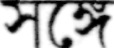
সঙ্গে
